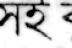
সহ
